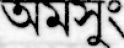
অমসুং
